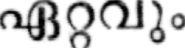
ഏറ്റവും
